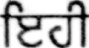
ਇਹੀ
